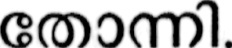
തോന്നി.
